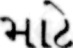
માટે
